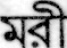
মরী
